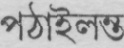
পঠাইলন্ত
